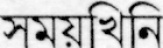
সময়খিনি
